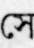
সে
